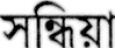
সন্ধিয়া
